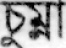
চুম্না
